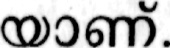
യാണ്.
